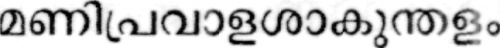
മണിപ്രവാളശാകുന്തളം
